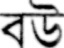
বউ
